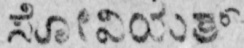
ಸೋವಿಯತ್
